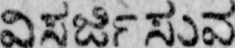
ವಿಸರ್ಜಿಸುವ
